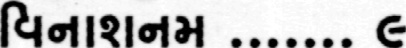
વિનાશનમ.......૯
